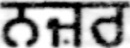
ਨਜ਼ਰ
